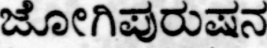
ಜೋಗಿಪುರುಷನ
